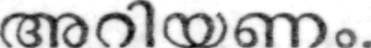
അറിയണം.
